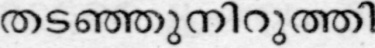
തടഞ്ഞുനിറുത്തി
